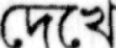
দেখে
